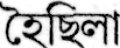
হৈছিলা
